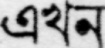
এখন
